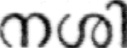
നശി
